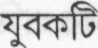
যুবকটি
